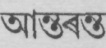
আন্তৰন্ত
